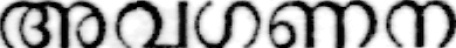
അവഗണന
